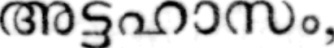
അട്ടഹാസം,
